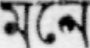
মনে
